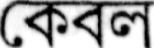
কেবল
